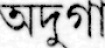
অদুগা
